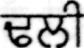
ਢਲੀ
